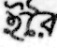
ইরৈ
